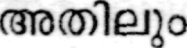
അതിലും
